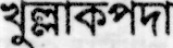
খুল্লাকপদা
